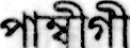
পাম্বীগী
